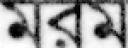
মরম
